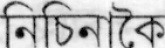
নিচিনাকৈ
